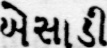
બેસાડી
